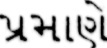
પ્રમાણે
